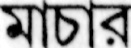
মাচার
